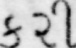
કરી
